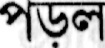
পড়ল
